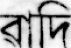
ৱাদি
